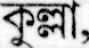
কুল্লা,
